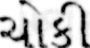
ચોકી
